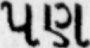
પણ
